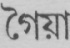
গৈয়া
